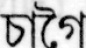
চাগৈ
